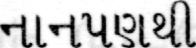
નાનપણથી
